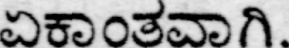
ಏಕಾಂತವಾಗಿ.
